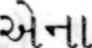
એના
